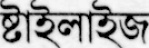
ষ্টাইলাইজ
